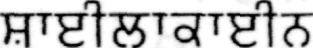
ਸ਼ਾਈਲਾਕਾਈਨ
